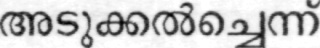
അടുക്കല്‍ച്ചെന്ന്
